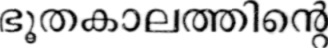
ഭൂതകാലത്തിന്റെ
